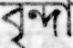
বৃন্দা
